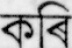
কৰি
